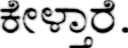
ಕೇಳ್ತಾರೆ.
